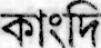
কাংদি
